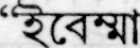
“ইবেম্মা
